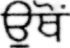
ਉਥੋਂ
